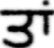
ਤਾਂ
